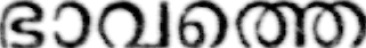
ഭാവത്തെ
